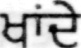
ਖਾਂਦੇ
